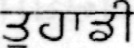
ਤੁਹਾਡੀ
